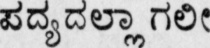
ಪದ್ಯದಲ್ಲಾಗಲೀ
